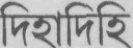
দিহাদিহি
